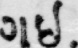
ગઈ.
